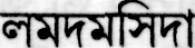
লমদমসিদা
